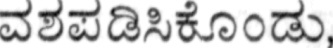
ವಶಪಡಿಸಿಕೊಂಡು,
